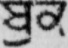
ਬੁਕ
